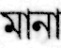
মানা
